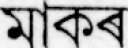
মাকৰ
